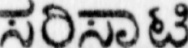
ಸರಿಸಾಟಿ
